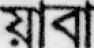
য়াবা
